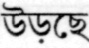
উড়ছে
